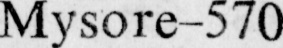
Mysore-570
